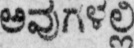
ಅವುಗಳಲ್ಲಿ
